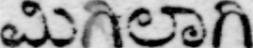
ಮಿಗಿಲಾಗಿ
